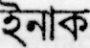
ইনাক
